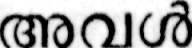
അവള്‍
